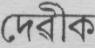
দেৱীক
